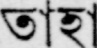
তাহা
